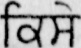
ਕਿਸੇ
